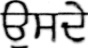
ਉਸਦੇ
